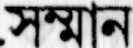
সম্মান
